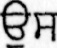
ਉਸ
